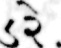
ડરે.
